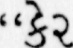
"કેર
